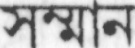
সম্মান
